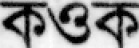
কওক
